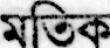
মতিক
